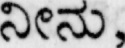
ನೀನು,
